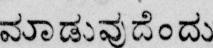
ಮಾಡುವುದೆಂದು
